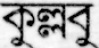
কুল্লবু
